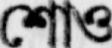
শোও
